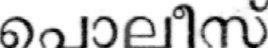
പൊലീസ്
